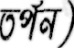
তর্পন)
